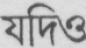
যদিও
